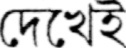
দেখেই
